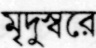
মৃদুস্বরে
